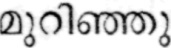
മുറിഞ്ഞു
